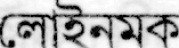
লোইনমক
